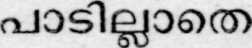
പാടില്ലാതെ
